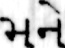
મને
